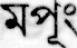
মপূং
